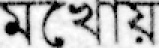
মখোয়
